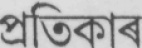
প্ৰতিকাৰ
